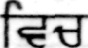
ਵਿਚ
